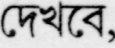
দেখবে,
